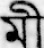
মী
